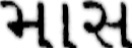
માસ
